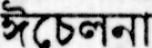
ঈচেলনা
